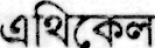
এথিকেল
